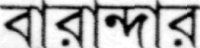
বারান্দার
